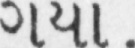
ગયા.
